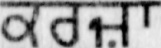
ਕਰਜ਼ਾ
